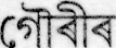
গৌৰীৰ
